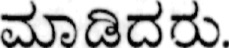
ಮಾಡಿದರು.
